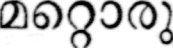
മറ്റൊരു
